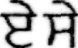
ਏਸੇ
